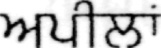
ਅਪੀਲਾਂ
